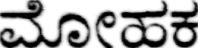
ಮೋಹಕ
